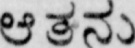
ಆತನು
